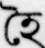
হৈ
